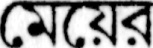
মেয়ের
